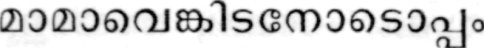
മാമാവെങ്കിടനോടൊപ്പം
